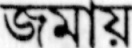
জমায়
